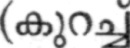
(കുറച്ച്
